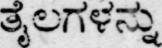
ತೈಲಗಳನ್ನು
